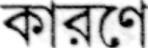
কারণে
